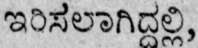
ಇರಿಸಲಾಗಿದ್ದಲ್ಲಿ,
